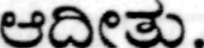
ಆದೀತು.
